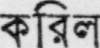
করিল
